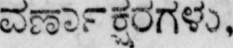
ವರ್ಣಾಕ್ಷರಗಳು,
